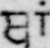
ਥਾਂ
